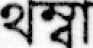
থম্বা
